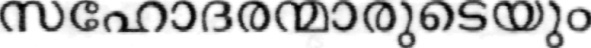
സഹോദരന്മാരുടെയും
